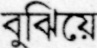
বুঝিয়ে
